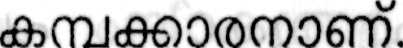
കമ്പക്കാരനാണ്.
